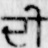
ਦੀ
